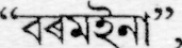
"বৰমইনা",
